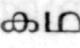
കഥ
